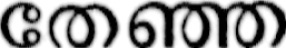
തേഞ്ഞ
